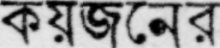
কয়জনের
